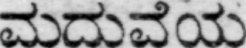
ಮದುವೆಯ
